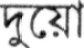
দুয়ো
